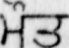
ਮੌਤ
